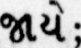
જાયે;
